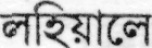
লহিয়ালে
